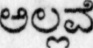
ಅಲ್ಲವೆ
